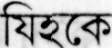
যিহকে
